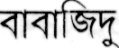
বাবাজিদু
